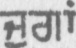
ਜੁਗਾਂ
